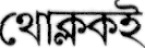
থোক্লকই
